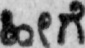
ಹೀಗೆ
